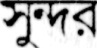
সুন্দর
